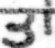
ਤਾਂ
